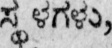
ಸ್ಥಳಗಳು,
